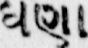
ઘણા
